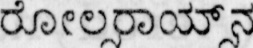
ರೋಲ್ಸರಾಯ್ಸ್ ನ
